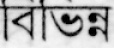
বিভিন্ন
